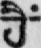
ਹੈਂ
